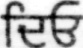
ਦਿਓ
